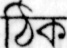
ঠিক
